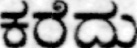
ಕರೆದು
